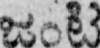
ಜಂಟಿ
